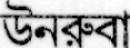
উনরুবা
